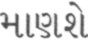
માણશે
